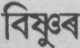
বিষ্ণুৰ
